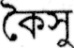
কৈসু
